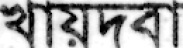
খায়দবা
